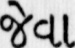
જેવા
